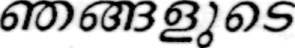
ഞങ്ങളുടെ
